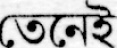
তেনেই
